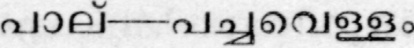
പാല്-പച്ചവെള്ളം
